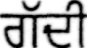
ਗੱਦੀ
